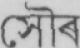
সৌৰ
